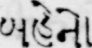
બહેનો
